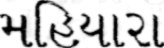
મહિયારા
